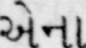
એના
